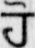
ਹੋ
